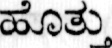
ಹೊತ್ತು
